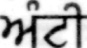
ਅੰਟੀ
